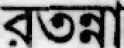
রতন্না
